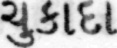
ચુકાદા
